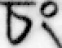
চং
